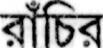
রাঁচির
